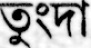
তুংদা
